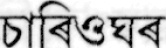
চাৰিওঘৰ
